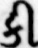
કી
